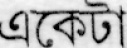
একেটা
